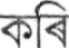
কৰি
